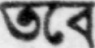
তবে
